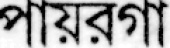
পায়রগা
